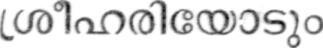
ശ്രീഹരിയോടും
